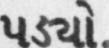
પડ્યો.
